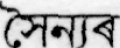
সৈন্যৰ
